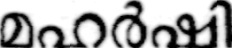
മഹര്‍ഷി
